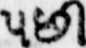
પછી
